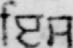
ਇਸ
